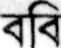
ববি
